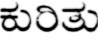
ಕುರಿತು
